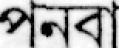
পনবা
